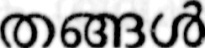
തങ്ങള്‍
